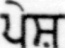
ਪੇਸ਼
